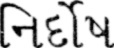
નિર્દોષ
